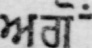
ਅਗੋਂ
